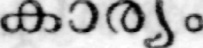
കാര്യം
